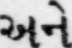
અને
